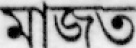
মাজত
